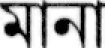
মানা
